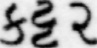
કટ્ટર
